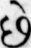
છે
